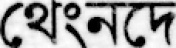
থেংনদে
